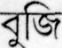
বুজি
